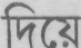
দিয়ে
